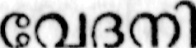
വേദനി
